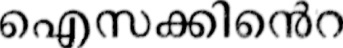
ഐസക്കിന്റെ
